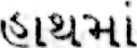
હાથમાં
